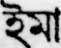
ইমা
